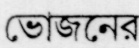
ভোজনের
